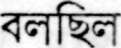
বলছিল
